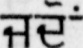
ਜਦੋਂ
